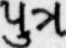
પુત્ર
